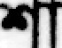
শা
